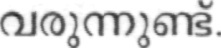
വരുന്നുണ്ട്.
